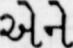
એને
